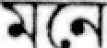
মনে
